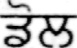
ਡੋਲ
